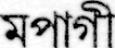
মপাগী
